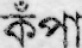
কঁপা
